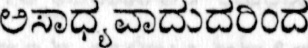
ಅಸಾಧ್ಯವಾದುದರಿಂದ
